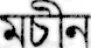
মচীন
